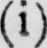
(i)
